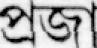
প্রজা
